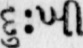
દુઃખી
